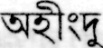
অহীংদু
